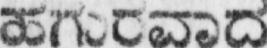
ಹಗುರವಾದ
